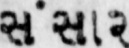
સંસાર
